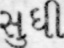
સુધી
